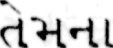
તેમના
